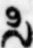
ಸಿ
